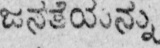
ಜನತೆಯನ್ನು
